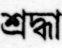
শ্রদ্ধা
